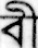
বী
